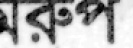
মরুপ
